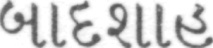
બાદશાહ
